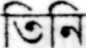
তিনি
